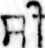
ਸੀ
